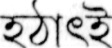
হঠাত্ই
